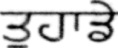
ਤੁਹਾਡੇ
